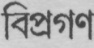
বিপ্ৰগণ
